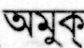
অমুক্
